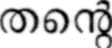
തന്റെ
